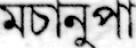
মচানুপা
